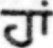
ਹਾਂ
